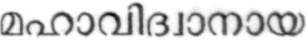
മഹാവിദ്വാനായ
